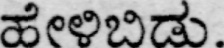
ಹೇಳಿಬಿಡು.
